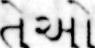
તેઓ
